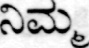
ನಿಮ್ಮ
